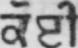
ਕੋਈ
